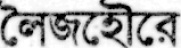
লৈজহৌরে
